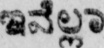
ಇವೆಲ್ಲಾ
